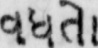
વધતો
